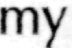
my
